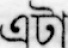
এটা
